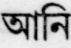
আনি
